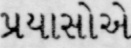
પ્રયાસોએ
